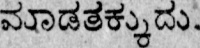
ಮಾಡತಕ್ಕುದು.
